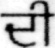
ਦੀ
